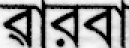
ৱারবা
